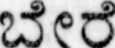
ಬೇರೆ
